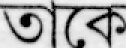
তাকে
